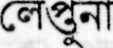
লেপ্তুনা
